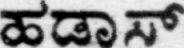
ಹಡಾಸ್
